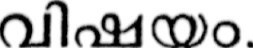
വിഷയം.
